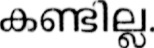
കണ്ടില്ല.
